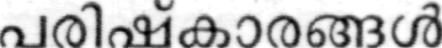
പരിഷ്കാരങ്ങള്‍
